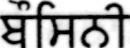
ਬੌਸਿਨੀ
